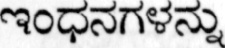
ಇಂಧನಗಳನ್ನು
